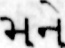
મને
